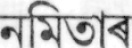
নমিতাৰ
